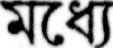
মধ্যে
